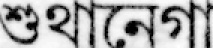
শুথানেগা
